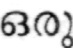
ഒരു
